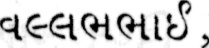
વલ્લભભાઈ,
